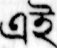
এই
